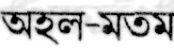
অহল-মতম
